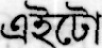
এইটো
